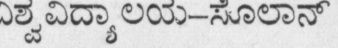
ವಿಶ್ವವಿದ್ಯಾಲಯ-ಸೊಲಾನ್
